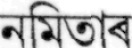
নমিতাৰ
